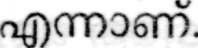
എന്നാണ്.
